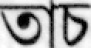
তাচ
